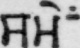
ਸਮੇਂ
